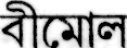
বীমোল
